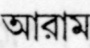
আরাম
